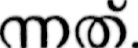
ന്നത്.
